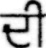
ਦੀ
